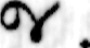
જ.
